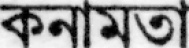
কনামতা
